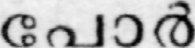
പോര്‍
